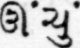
ઊંચુ
